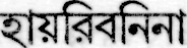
হায়রিবনিনা
